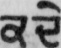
ਕਦੇ
